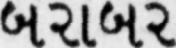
બરાબર
